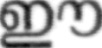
ഈ
